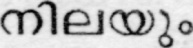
നിലയും
